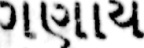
ગણાય
